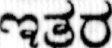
ಇತರ
